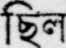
ছিল
